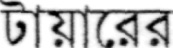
টায়ারের
